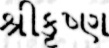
શ્રીકૃષ્ણ
